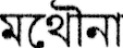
মথৌনা
